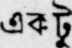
একটু
